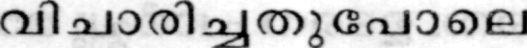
വിചാരിച്ചതുപോലെ
